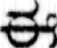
ಈ
